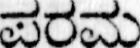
ಪರಮ
